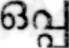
ഒപ്പ
